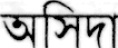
অসিদা
